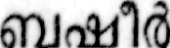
ബഷീര്‍
